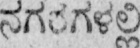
ನಗರಗಳಲ್ಲಿ
